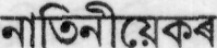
নাতিনীয়েকৰ
